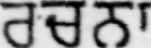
ਰਚਨਾ
